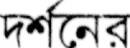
দর্শনের
